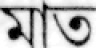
মাত
